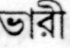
ভারী
